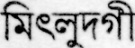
মিৎলুদগী
